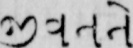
જીવનને
